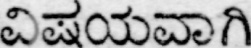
ವಿಷಯವಾಗಿ
